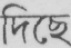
দিছে
